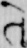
તે
